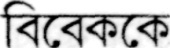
বিবেককে
